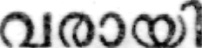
വരായി
